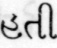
હતી
